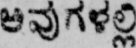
ಅವುಗಳಲ್ಲಿ
